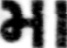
મા
